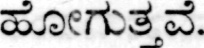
ಹೋಗುತ್ತವೆ.
